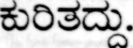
ಕುರಿತದ್ದು.
